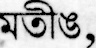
মতীঙ,
